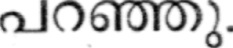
പറഞ്ഞു.
